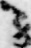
કે
